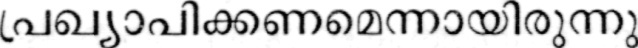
പ്രഖ്യാപിക്കണമെന്നായിരുന്നു
